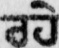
ਰਹੇ
